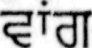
ਵਾਂਗ
